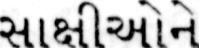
સાક્ષીઓને
